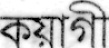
কয়াগী
